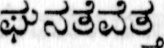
ಘನತೆವೆತ್ತ
